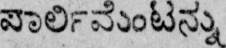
ಪಾರ್ಲಿಮೆಂಟನ್ನು
